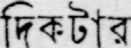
দিকটার
